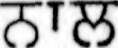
ਨਾਲ
